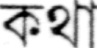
কথা
